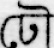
ঢৌ
